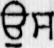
ਉਸ
